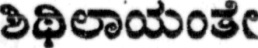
ಶಿಥಿಲಾಯಂತೇ
